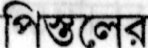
পিস্তলের
